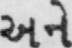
અને
